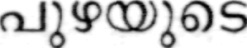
പുഴയുടെ
